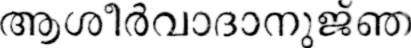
ആശീര്‍വാദാനുജ്ഞ
